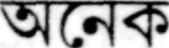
অনেক
